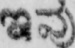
ಇವು
